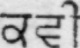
ਕਵੀ
